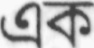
এক
